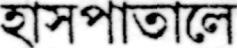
হাসপাতালে
